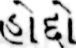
હોદ્દો
